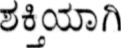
ಶಕ್ತಿಯಾಗಿ
